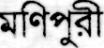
মণিপুরী
